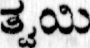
ತ್ವಯಿ
